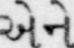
એને
